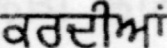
ਕਰਦੀਆਂ
